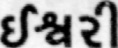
ઈશ્વરી
